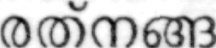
രത്നങ്ങ
